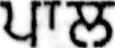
ਪਾਲ
